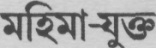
মহিমা-যুক্ত
